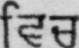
ਵਿਚ
